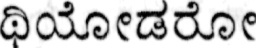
ಥಿಯೋಡರೋ
